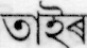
তাইৰ
